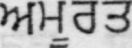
ਅਮੂਰਤ
